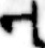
ન
